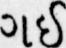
ગઈ
